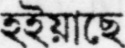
হইয়াছে
